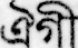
ঐগী
